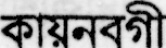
কায়নবগী
